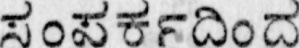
ಸಂಪರ್ಕದಿಂದ
